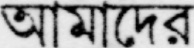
আমাদের
